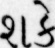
શકે
